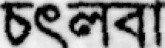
চৎলবা
